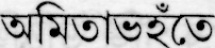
অমিতাভহঁতে
